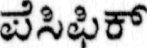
ಪೆಸಿಫಿಕ್
